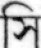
সি
